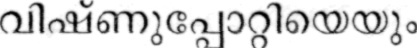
വിഷ്ണുപ്പോറ്റിയെയും
